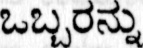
ಒಬ್ಬರನ್ನು
